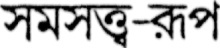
সমসত্ত্ব-রূপ
